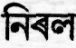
নিৰল
